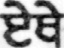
ਏਥੇ
